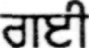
ਗਈ
